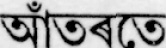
আঁতৰতে
